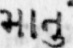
માનું
